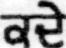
ਕਦੇ
